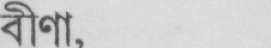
বীণা,
